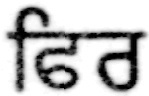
ਫਿਰ
